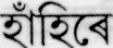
হাঁহিৰে
